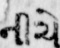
નીચે
